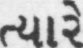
ત્યારે
